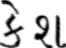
કેશ
